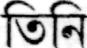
তিনি
